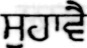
ਸੁਹਾਵੈ
